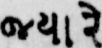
જ્યારે
